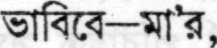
ভাবিবে—মা’র,
